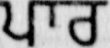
ਪਾਰ
